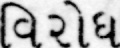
વિરોધ
